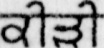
ਕੀੜੀ
